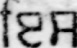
ਇਸ
